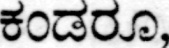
ಕಂಡರೂ,
